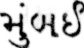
મુંબઈ
